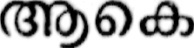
ആകെ
